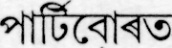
পাৰ্টিবোৰত
